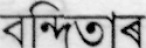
বন্দিতাৰ
